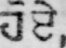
ਹੋਏ,
